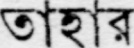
তাহার
